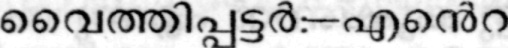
വൈത്തിപ്പട്ടര്‍:-എന്റെ
